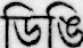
ডিঙি
